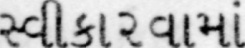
સ્વીકારવામાં
